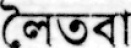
লৈতবা
